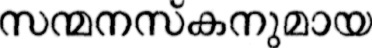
സന്മനസ്കനുമായ
